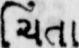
ચિંતા
